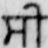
ਸੀ
